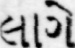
લાગે
